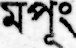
মপূং
